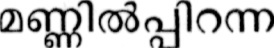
മണ്ണില്‍പ്പിറന്ന
